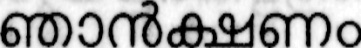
ഞാന്‍ക്ഷണം
